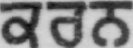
ਕਰਨ
